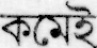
কমেই
